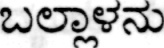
ಬಲ್ಲಾಳನು
